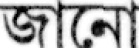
জানো
